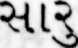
સારુ
